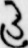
હે
